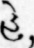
હે,
